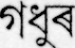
গধুৰ
